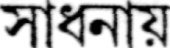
সাধনায়
